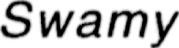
Swamy
